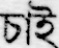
চাই
